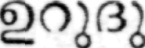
ഉറുദു
